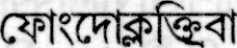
ফোংদোক্লক্ত্রিবা
